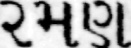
રમણ
